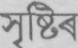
সৃষ্টিৰ
